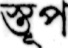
স্তূপ
